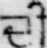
ਦੀ
